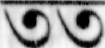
তত
